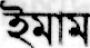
ইমাম
